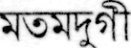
মতমদুগী
